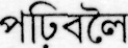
পঢ়িবলৈ
